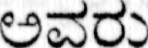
ಅವರು
